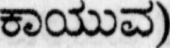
ಕಾಯುವ)
